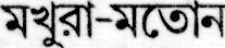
মখুরা-মতোন
